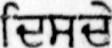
ਦਿਸਦੇ
